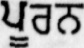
ਪੂਰਨ
